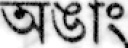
অঙাং
